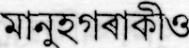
মানুহগৰাকীও
